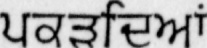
ਪਕੜਦਿਆਂ
